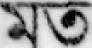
মত
